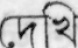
দেখি
